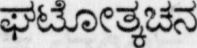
ಘಟೋತ್ಕಚನ
